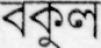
বকুল
